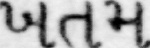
ખતમ
